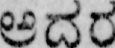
ಅದರ
